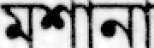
মশানা
